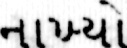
નાખ્યો
